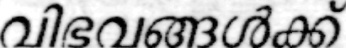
വിഭവങ്ങള്‍ക്ക്
